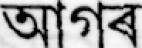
আগৰ
